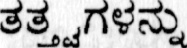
ತತ್ತ್ವಗಳನ್ನು
